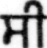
ਸੀ
